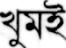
খুমই
